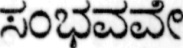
ಸಂಭವವೇ
